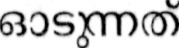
ഓടുന്നത്
